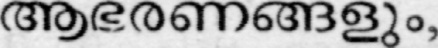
ആഭരണങ്ങളും,
